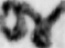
જ
